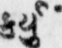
કર્યું
